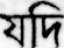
যদি
